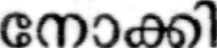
നോക്കി
